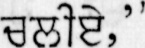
ਚਲੀਏ,''
